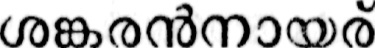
ശങ്കരന്‍നായര്
